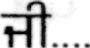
ਜੀ.....
